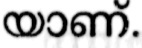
യാണ്.
